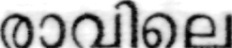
രാവിലെ
